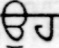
ਉਹ
